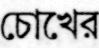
চোখের
